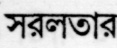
সরলতার
